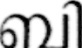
ബി
